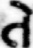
તે
